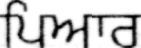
ਪਿਆਰ
